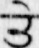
ਤੇ
